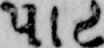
પાટ
